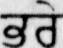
ਭਰੇ
